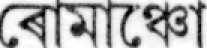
ৰোমাঞ্চো
